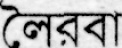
লৈরবা
